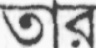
তার
